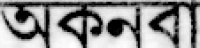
অকনবা
